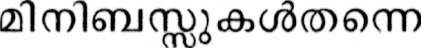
മിനിബസ്സുകള്‍തന്നെ
